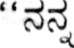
"ನನ್ನ
